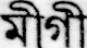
মীগী
